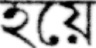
হয়ে
